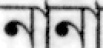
নানা
